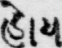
હોય
